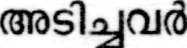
അടിച്ചവര്‍
